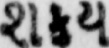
શક્ય
